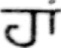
ਹਾਂ
